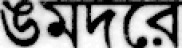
ঙমদরে
